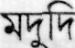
মদুদি
